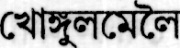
খোঙ্গুলমেলৈ
